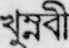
খুম্নবী
